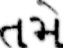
તમે
